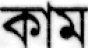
কাম
